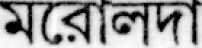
মরোলদা
